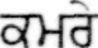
ਕਮਰੇ
